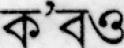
ক'বও
